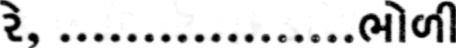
રે,............ભોળી
